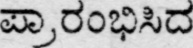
ಪ್ರಾರಂಭಿಸಿದ
